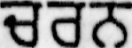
ਚਰਨ
